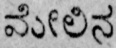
ಮೇಲಿನ
